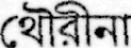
থৌরীনা
